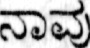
ನಾವು
